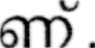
ണ്.
